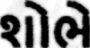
શોભે
